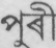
পুৰী
